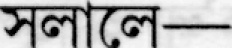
সলালে-
